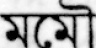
মমৌ
